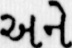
અને
